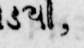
પડ્યો,
